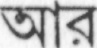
আর
